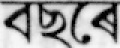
বছৰে
